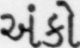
અંકો
